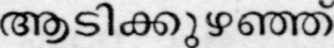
ആടിക്കുഴഞ്ഞ്
